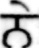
ਨੇ
